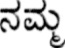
ನಮ್ಮ
